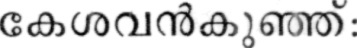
കേശവന്‍കുഞ്ഞ്:
